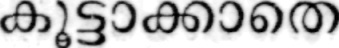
കൂട്ടാക്കാതെ
